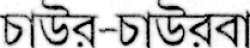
চাউর-চাউরবা
